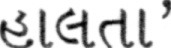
હાલતા'
